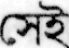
সেই
